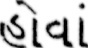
હોવાં
